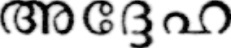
അദ്ദേഹ
